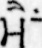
ਮੈਂ
